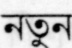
নতুন
